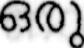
ഒരു
